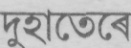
দুহাতেৰে
